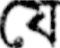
যে
